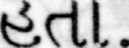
હતા.
